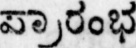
ಪ್ರಾರಂಭ
